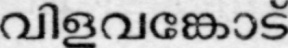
വിളവങ്കോട്
